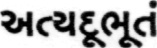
અત્યદૂભૂતં
